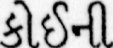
કોઈની
